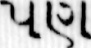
પણ
